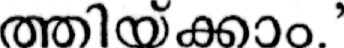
ത്തിയ്ക്കാം.’
